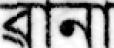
ৱানা
